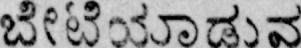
ಬೇಟೆಯಾಡುವ
